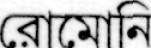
রোমোনি
